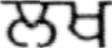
ਲਖ
